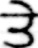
ਤੇ
